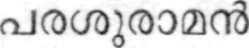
പരശുരാമന്‍
